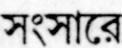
সংসারে
